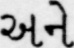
અને
